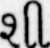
શી
